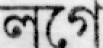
লগে
